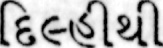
દિલ્હીથી
